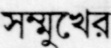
সম্মুখের
